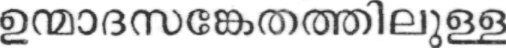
ഉന്മാദസങ്കേതത്തിലുള്ള
